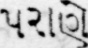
પરાણે
